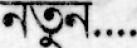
নতুন....
